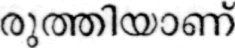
രുത്തിയാണ്
